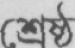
শ্ৰেষ্ঠ
